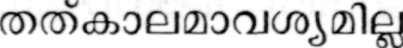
തത്കാലമാവശ്യമില്ല
